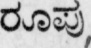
ರೂಪು
